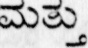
ಮತ್ತು
